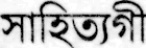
সাহিত্যগী
